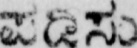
ಪಡಿಸು
